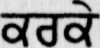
ਕਰਕੇ
